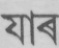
যাৰ
